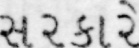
સરકારે
